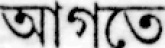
আগতে
